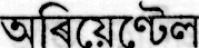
অৰিয়েণ্টেল
